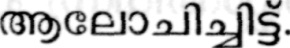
ആലോചിച്ചിട്ട്.
